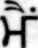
ਮੈਂ
